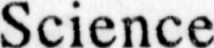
Science
